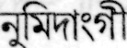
নুমিদাংগী
